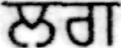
ਲਗ
